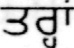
ਤਰ੍ਹਾਂ
